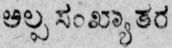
ಅಲ್ಪಸಂಖ್ಯಾತರ
